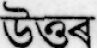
উত্তৰ
